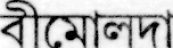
বীমোলদা
